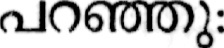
പറഞ്ഞു:
